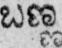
ಬಣ್ಣ
